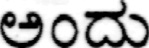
ಅಂದು
